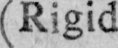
(Rigid
